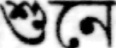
শুনে
